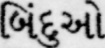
બિંદુઓ
